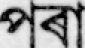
পৰা
